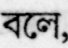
বলে,
